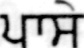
ਪਾਸੇ
